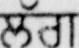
ਲੱਗ
